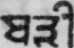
ਬੜੀ
